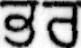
ਭਰ
